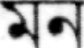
মন
